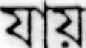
যায়
